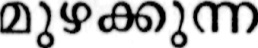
മുഴക്കുന്ന
